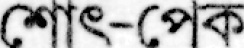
শোৎ-পেক
